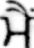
ਮੈਂ
